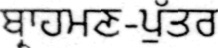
ਬ੍ਰਾਹਮਣ-ਪੁੱਤਰ
